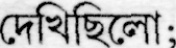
দেখিছিলো;
